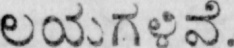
ಲಯಗಳಿವೆ.
